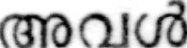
അവള്‍
